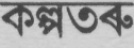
কল্পতৰু
